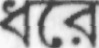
ধরে
